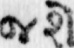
જશે
